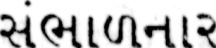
સંભાળનાર
